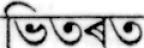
ভিতৰত
